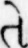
તે
